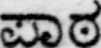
ಪಾಠ
